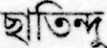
ছাতিন্দু
